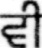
ਵੀ
